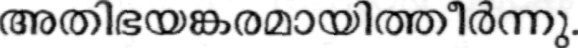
അതിഭയങ്കരമായിത്തീര്‍ന്നു.
